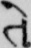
તે
